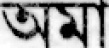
অমা
